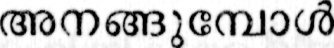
അനങ്ങുമ്പോള്‍
